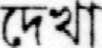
দেখা
